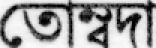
তোম্বদা
